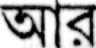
আর
